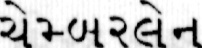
ચેમ્બરલેન
